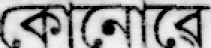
কোনোৱে
